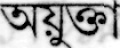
অয়ুক্তা
